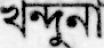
খন্দুনা
